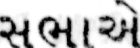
સભાએ
